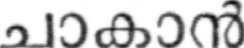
ചാകാന്‍
